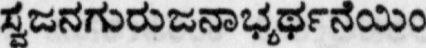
ಸ್ವಜನಗುರುಜನಾಭ್ಯರ್ಥನೆಯಿಂ
